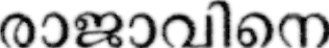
രാജാവിനെ
